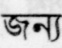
জন্য
